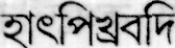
হাৎপিখ্রবদি
